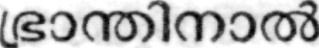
ഭ്രാന്തിനാല്‍
